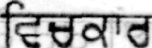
ਵਿਚਕਾਰ
